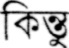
কিন্তু
